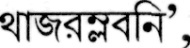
থাজরম্লবনি’,
